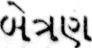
બેત્રણ
